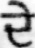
ਦੇ
